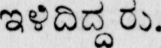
ಇಳಿದಿದ್ದರು.
